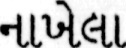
નાખેલા
